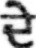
ਦੇ
